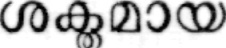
ശക്തമായ
